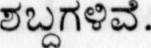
ಶಬ್ದಗಳಿವೆ.
